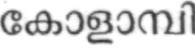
കോളാമ്പി
